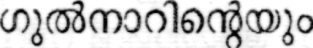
ഗുല്‍നാറിന്റെയും
